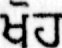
ਖੋਹ
